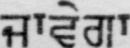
ਜਾਵੇਗਾ
